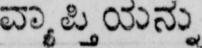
ವ್ಯಾಪ್ತಿಯನ್ನು
